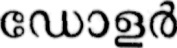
ഡോളര്‍
